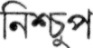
নিশ্চুপ
